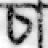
চা
